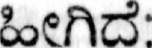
ಹೀಗಿದೆ:
